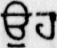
ਉਹ
